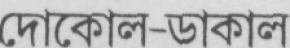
দোকোল-ডাকাল
